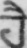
ਹੈ
